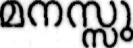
മനസ്സു
